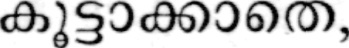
കൂട്ടാക്കാതെ,
